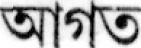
আগত
